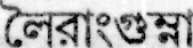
লৈরাংগুম্না
